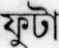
ফুটা
